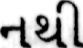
નથી
